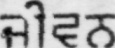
ਜੀਵਨ
